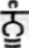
ਨੂੰ
